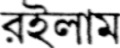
রইলাম
